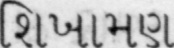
શિખામણ
